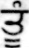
ਤੂੰ
